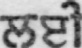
ਲਈ
